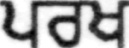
ਪਰਖ
